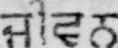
ਜੀਵਨ
